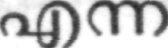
എന്ന
